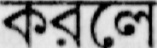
করলে
